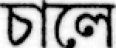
চালে
